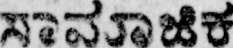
ಸಾಮಾಜಿಕ
